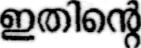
ഇതിന്റെ
